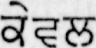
ਕੇਵਲ
